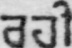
ਰਹੀ
